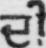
ਦੀ
